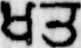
ਖਤ
